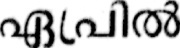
ഏപ്രില്‍
